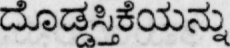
ದೊಡ್ಡಸ್ತಿಕೆಯನ್ನು
